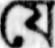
যে
